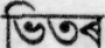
ভিতৰ
